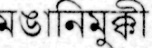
মঙানিমুক্কী
